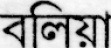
বলিয়া
